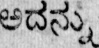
ಅದನ್ನು
